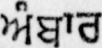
ਅੰਬਾਰ
